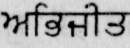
ਅਭਿਜੀਤ
